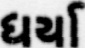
ધર્યા
